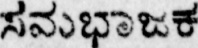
ಸಮಭಾಜಕ
